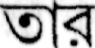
তার
